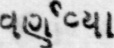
વર્ણવ્યા
